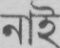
নাই
